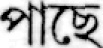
পাছে
